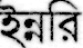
ইন্নরি
